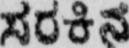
ಸರಕಿನ
